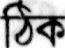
ঠিক
